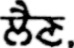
ਲੈਣ,
